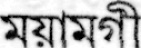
ময়ামগী
